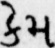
કેમ
